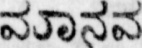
ಮಾನವ
